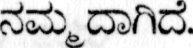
ನಮ್ಮದಾಗಿದೆ.
